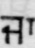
ਜਾ
